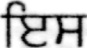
ਇਸ
